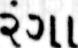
રંગા
